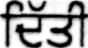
ਦਿੱਤੀ
